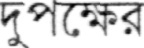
দুপক্ষের
